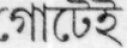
গোটেই
